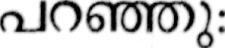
പറഞ്ഞു:
